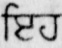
ਇਹ
